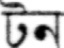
টন
